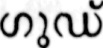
ഗുഡ്
